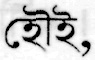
হৌই,
